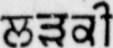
ਲੜਕੀ
